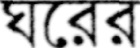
ঘরের
